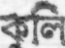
কুলি
